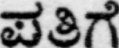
ಪತಿಗೆ
